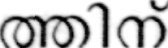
ത്തിന്
